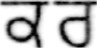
ਕਰ
